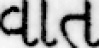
વાત
